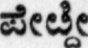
ಪೇೞ್ದೇ
